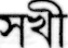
সখী
